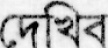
দেখিব
